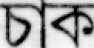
চাক
